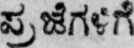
ಪ್ರಜೆಗಳಿಗೆ
